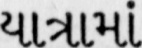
યાત્રામાં
